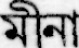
মীমা
